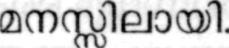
മനസ്സിലായി.
